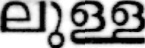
ലുള്ള
